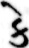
કે
